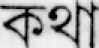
কথা
